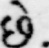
છે.
